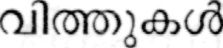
വിത്തുകള്‍
